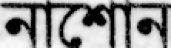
নাশোন
